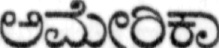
ಅಮೇರಿಕಾ
